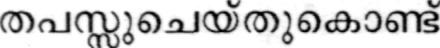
തപസ്സുചെയ്തുകൊണ്ട്
